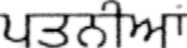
ਪਤਨੀਆਂ
